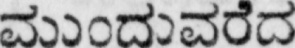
ಮುಂದುವರೆದ
